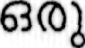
ഒരു
